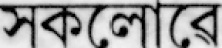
সকলোৱে
